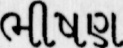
ભીષણ
